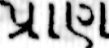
પ્રાણ
